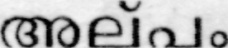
അല്പം
